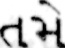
તમે
